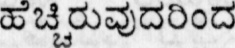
ಹೆಚ್ಚಿರುವುದರಿಂದ
